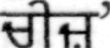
ਚੀਜ਼'
